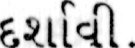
દર્શાવી.
